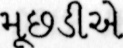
મૂછડીએ
